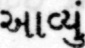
આવ્યું
